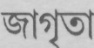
জাগৃতা
